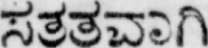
ಸತತವಾಗಿ
